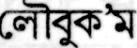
লৌবুক’ম
